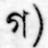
গ)
